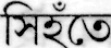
সিহঁতে
